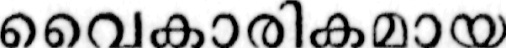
വൈകാരികമായ
